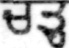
ਚੜ੍ਹ
